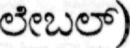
ಲೇಬಲ್)
